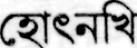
হোৎনখি
